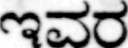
ಇವರ
